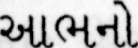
આભનો
